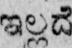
ಇಲ್ಲದೆ
